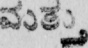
ಮತ್ತು
